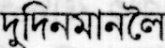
দুদিনমানলৈ
